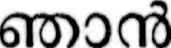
ഞാന്‍
